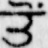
ਤੋਂ
